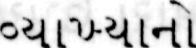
વ્યાખ્યાનો
